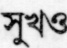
সুখও
